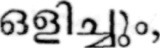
ഒളിച്ചും,
